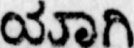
ಯಾಗಿ
